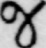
જ
